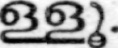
ള്ളൂ.
